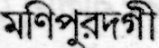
মণিপুরদগী
